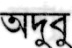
অদুবু
